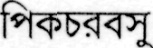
পিকচরবসু
